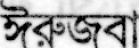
ঈরুজবা
